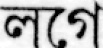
লগে
